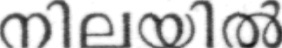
നിലയില്‍
